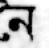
নৈ
